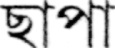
ছাপা
